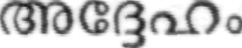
അദ്ദേഹം
